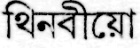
থিনবীয়ো
